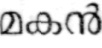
മകന്‍
